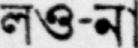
লও-না
